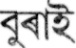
বুৰাই
